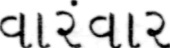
વારંવાર
